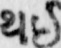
થઈ
